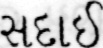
સદાઈ
